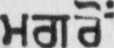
ਮਗਰੋਂ
